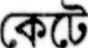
কেটে
